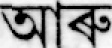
আৰু
